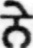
ਨੇ
